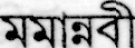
মমান্নবী
